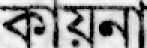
কায়না
